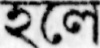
হলে
